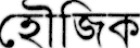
হৌজিক
